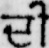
ਦੀ
